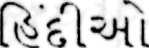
હિંદીઓ
